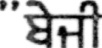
''ਬੇਜੀ
